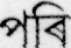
পৰি
